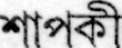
শাপকী
